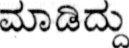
ಮಾಡಿದ್ದು
